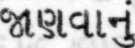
જાણવાનું
